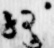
કરું
